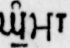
ਘੁੰਮਾ
